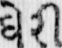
ઘેરી
